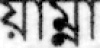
য়াম্না
